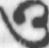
ও
